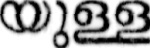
യുള്ള
